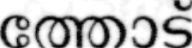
ത്തോട്
